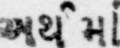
અર્થમાં
